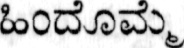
ಹಿಂದೊಮ್ಮೆ
